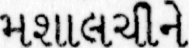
મશાલચીને
